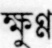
ক্ষুণ্ণ
